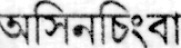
অসিনচিংবা
